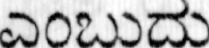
ಎಂಬುದು
